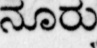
ನೂರು
